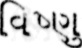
વિષ્ણુ
